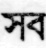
সব
